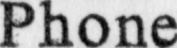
Phone
